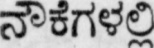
ನೌಕೆಗಳಲ್ಲಿ
